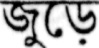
জুড়ে
